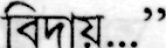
বিদায়..."
